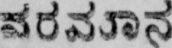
ವರಮಾನ
